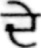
ਦੇ
